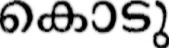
കൊടു
